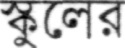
স্কুলের
